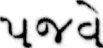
પજવે
